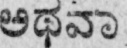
ಅಥವಾ
